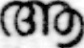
ആ
